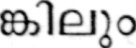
ങ്കിലും
